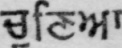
ਚੁਣਿਆ
